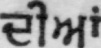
ਦੀਆਂ
